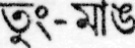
তুং-মাঙ
